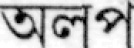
অলপ
